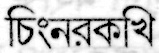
চিংনরকখি
